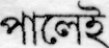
পালেই
